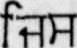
ਜਿਸ
